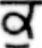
ਕੁ
